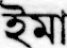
ইমা
